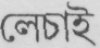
লেচাই
